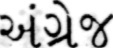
અંગ્રેજ
